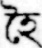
হৈ
